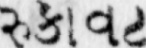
રુકાવટ
